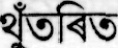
থুঁতৰিত
